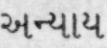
અન્યાય
